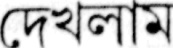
দেখলাম
